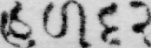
હળદર
